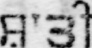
ਸ਼ਾਤੀ
